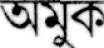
অমুক
